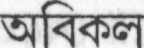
অবিকল
